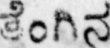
ತೆಂಗಿನ
